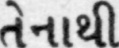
તેનાથી
